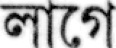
লাগে
